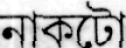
নাকটো
